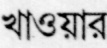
খাওয়ার
